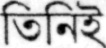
তিনিই
